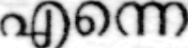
എന്നെ
